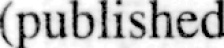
(published
